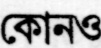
কোনও
